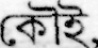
কৌই,
